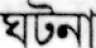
ঘটনা
